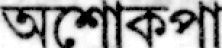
অশোকপা
